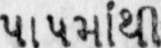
પાપમાંથી
